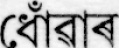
ধোঁৱাৰ
